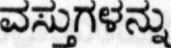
ವಸ್ತುಗಳನ್ನು
